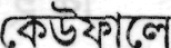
কেউফালে
